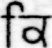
ਕਿ
